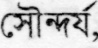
সৌন্দর্য,
